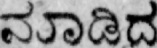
ಮಾಡಿದ
